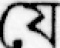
যে
